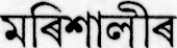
মৰিশালীৰ
